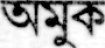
অমুক
